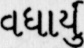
વધાર્યું
